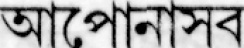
আপোনাসব
